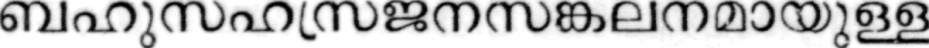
ബഹുസഹസ്രജനസങ്കലനമായുള്ള
